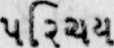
પરિચય
